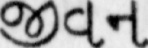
જીવન
